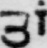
ਤਾਂ
